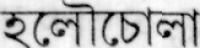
হলৌচোলা
